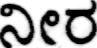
ನೀರ
